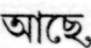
আছে,
